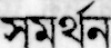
সমর্থন
